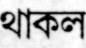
থাকল
